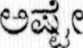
ಅಷ್ಟೇ
